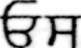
ਓਸ
